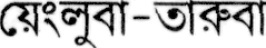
য়েংলুবা-তারুবা
